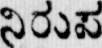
ನಿರುಪ
